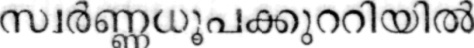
സ്വര്‍ണ്ണധൂപക്കുററിയില്‍
